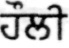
ਹੌਲੀ
